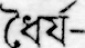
ধৈর্য-
